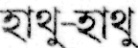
হাথু-হাথু
